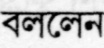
বললেন
